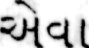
એવા
